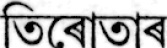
তিৰোতাৰ
